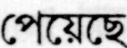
পেয়েছে
